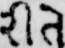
રીતે
